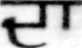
ਦਾ
